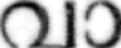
വാ
